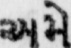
અમે
